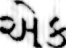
એક
